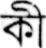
কী
